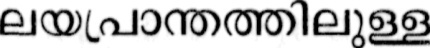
ലയപ്രാന്തത്തിലുള്ള
